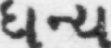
ધન્ય
